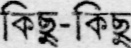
কিছু-কিছু
